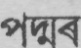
পদ্মৰ
